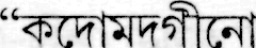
“কদোমদগীনো
